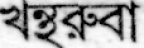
খন্থরুবা
